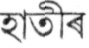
হাতীৰ
